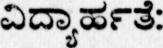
ವಿದ್ಯಾರ್ಹತೆ:
